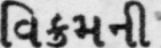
વિક્રમની
